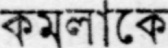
কমলাকে
